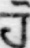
ਹੋ
